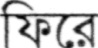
ফিরে
